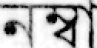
নম্বা
